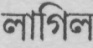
লাগিল
